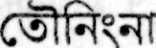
তৌনিংনা
